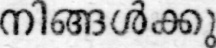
നിങ്ങള്‍ക്കു
